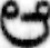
ಆ
